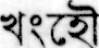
খংহৌ
